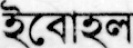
ইবোহল
